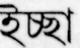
ইচ্ছা
